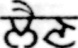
ਲੈਣ
